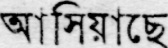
আসিয়াছে
